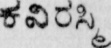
ಕವಿರಸ್ಮಿ
